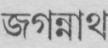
জগন্নাথ
